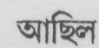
আছিল
